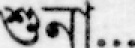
শুনা...
